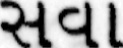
સવા
